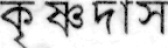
কৃষ্ণদাস
